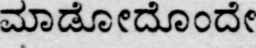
ಮಾಡೋದೊಂದೇ
